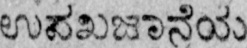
ಉಪಖಜಾನೆಯ
